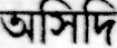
অসিদি
